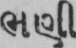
ભણી
